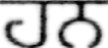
ਹਨ
